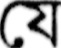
যে
